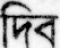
দিব
